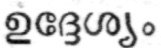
ഉദ്യേശ്യം
